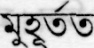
মুহূর্তত
